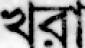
খরা
